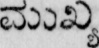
ಮುಖ್ಯ
